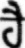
ਹੈ
